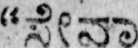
“ಸೇವಾ
